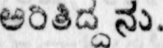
ಅರಿತಿದ್ದನು.
